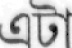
এটা
